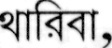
থারিবা,
